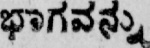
ಭಾಗವನ್ನು
